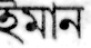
ইমান
